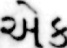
એક
